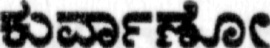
ಕುರ್ವಾಣೋ
